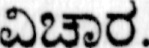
ವಿಚಾರ.
